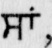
ਸਾਂ,
